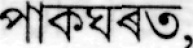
পাকঘৰত,
